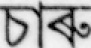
চাৰু
